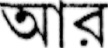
আর
